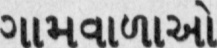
ગામવાળાઓ
